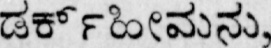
ಡರ್ಕ್‌ಹೀಮನು,
